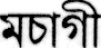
মচাগী
